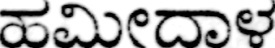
ಹಮೀದಾಳ
